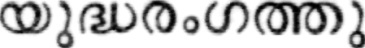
യുദ്ധരംഗത്തു
